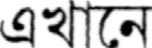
এখানে
